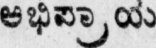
ಅಭಿಪ್ರಾಯ
